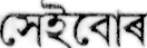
সেইবোৰ
